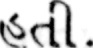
હતી.
